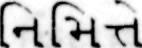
નિમિત્તે
